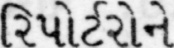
રિપોર્ટરોને
